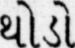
થોડો
